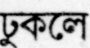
ঢুকলে
